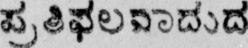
ಪ್ರತಿಫಲವಾದುದ
